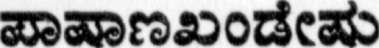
ಪಾಷಾಣಖ೦ಡೇಷು
